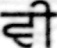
ਵੀ
